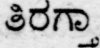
ತಿರಗ್ತಾ
